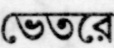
ভেতরে
